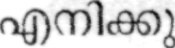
എനിക്കു
